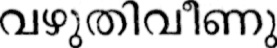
വഴുതിവീണു
